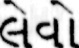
લેવો
